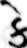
કે
